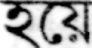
হয়ে
